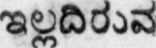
ಇಲ್ಲದಿರುವ
